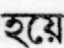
হয়ে
